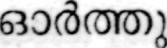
ഓര്‍ത്തു
